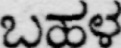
ಬಹಳ
